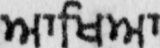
ਆਖਿਆ
